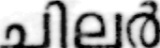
ചിലര്‍
